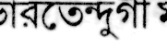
ঙারতেন্দুগী
